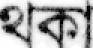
থকা
